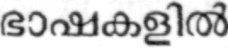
ഭാഷകളില്‍
